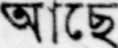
আছে
